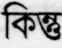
কিন্তু
